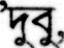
’দুবু,
